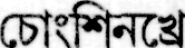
চোংশিনখ্রে
